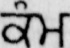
ਕੰਮ
